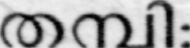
തമ്പി:
